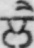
ਲੈ
